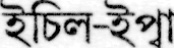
ইচিল-ইপ্বা
